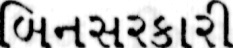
બિનસરકારી
